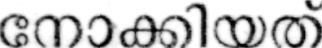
നോക്കിയത്
